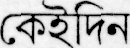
কেইদিন
